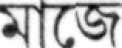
মাজে
